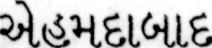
એહમદાબાદ
